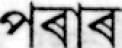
পৰাৰ
